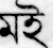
মই
